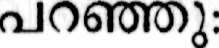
പറഞ്ഞു:
